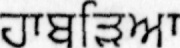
ਹਾਬੜਿਆ
